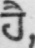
ਹੈ,
